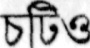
চটিও
